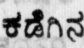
ಕಡೆಗಿನ
